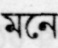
মনে
